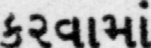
કરવામાં
